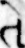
તે
